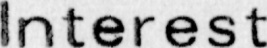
Interest
